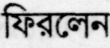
ফিরলেন
